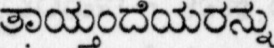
ತಾಯ್ತಂದೆಯರನ್ನು
